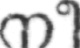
നീ
